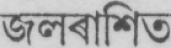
জলৰাশিত
